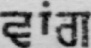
ਵਾਂਗ
